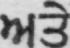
ਅਤੇ
